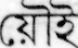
য়ৌই
